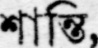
শান্তি,
